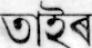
তাইৰ
